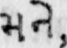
મને,
